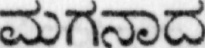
ಮಗನಾದ
